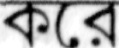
করে
